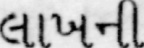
લાખની
